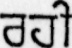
ਰਹੀ
